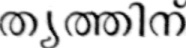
ത്യത്തിന്
